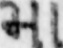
મા
